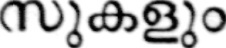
സുകളും
